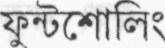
ফুন্টশোলিং
